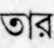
তার
